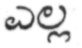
ಎಲ್ಲ
